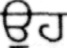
ਉਹ
